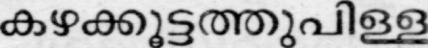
കഴക്കൂട്ടത്തുപിള്ള
